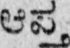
ಆಪ್ತ
